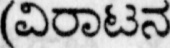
(ವಿರಾಟನ
